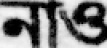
নাও
